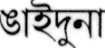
ঙাইদুনা
